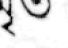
মৃত
